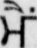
ਮੈਂ
